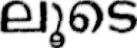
ലൂടെ
